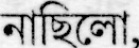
নাছিলো,
